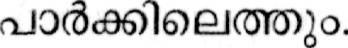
പാര്‍ക്കിലെത്തും.
